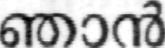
ഞാന്‍
